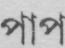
পাপ
